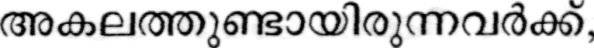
അകലത്തുണ്ടായിരുന്നവര്‍ക്ക്,
